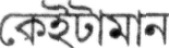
কেইটামান
